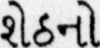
શેઠનો
